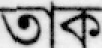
তাক
